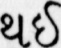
થઈ
